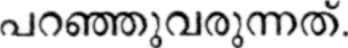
പറഞ്ഞുവരുന്നത്.
